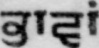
ਭਾਵਾਂ
